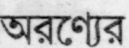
অরণ্যের
